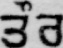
ਤੌਰ
